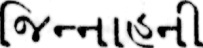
જિન્નાહની
